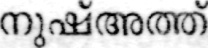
നുഷ്അത്ത്
